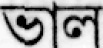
ভাল
